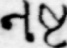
નષ્ટ
